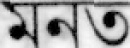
মনত
